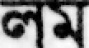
লম
